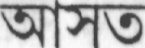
আসত
